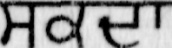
ਸਕਦਾ
